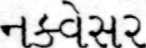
નકવેસર
